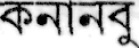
কনানবু
